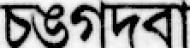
চঙগদবা
